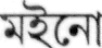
মইনো
